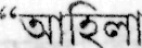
"আহিলা
